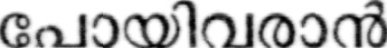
പോയിവരാന്‍
